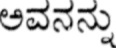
ಅವನನ್ನು
